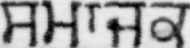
ਸਮਾਜਕ
